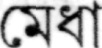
মেধা
